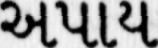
અપાય
